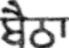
ਬੈਠਾ
